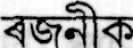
ৰজনীক
